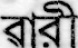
ৱারী
